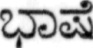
ಭಾಷೆ
